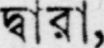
দ্বারা,
